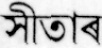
সীতাৰ
